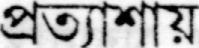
প্রত্যাশায়
